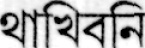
থাখিবনি
